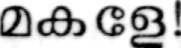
മകളേ!
